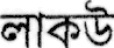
লাকউ
